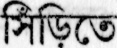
সিঁড়িতে
